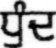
ਧੁੰਦ
